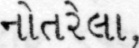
નોતરેલા,
